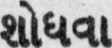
શોધવા
